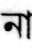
না
